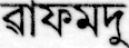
ৱাফমদু
